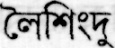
লৈশিংদু
